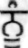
ਨੂੰ
